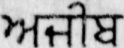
ਅਜੀਬ
